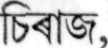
চিৰাজ,
